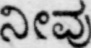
ನೀವು
